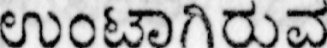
ಉಂಟಾಗಿರುವ
